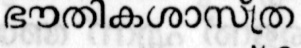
ഭൌതികശാസ്ത്ര
